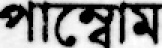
পাম্বোম
